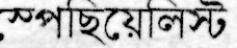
স্পেছিয়েলিস্ট
